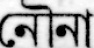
নৌনা
